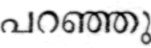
പറഞ്ഞു
